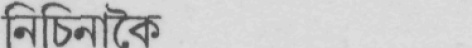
নিচিনাকৈ
